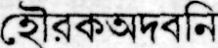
হৌরকঅদবনি
